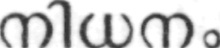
നിധനം
